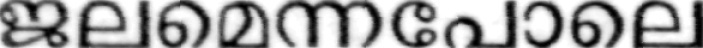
ജലമെന്നപോലെ
